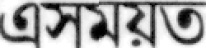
এসময়ত
